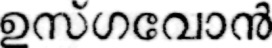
ഉസ്ഗവോന്‍
